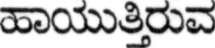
ಹಾಯುತ್ತಿರುವ
